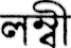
লম্বী
